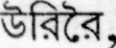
উরিরৈ,
